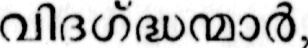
വിദഗ്ദ്ധന്മാര്‍,
